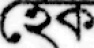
হেক
